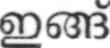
ഇങ്ങ്
